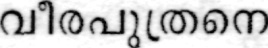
വീരപുത്രനെ
